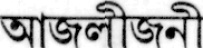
আজলীজনী
